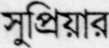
সুপ্রিয়ার
